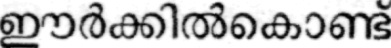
ഈര്‍ക്കില്‍കൊണ്ട്
